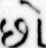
છો
